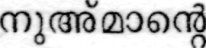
നുഅ്മാന്റെ
